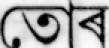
তোৰ
